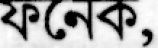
ফনেক,
